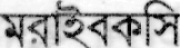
মরাইবকসি
